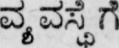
ವ್ಯವಸ್ಥೆಗೆ
